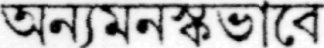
অন্যমনস্কভাবে
